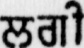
ਲਗੀ
